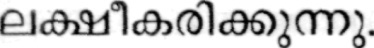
ലക്ഷീകരിക്കുന്നു.
